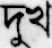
দুখ
